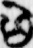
છે
